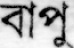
বাপু
